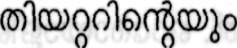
തിയറ്ററിന്റെയും
